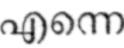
എന്നെ
